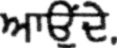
ਆਉਂਦੇ
